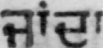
ਜਾਂਦਾ
